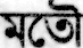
মতৌ
